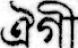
ঐগী
